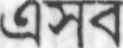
এসব
